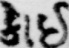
કોઈ
